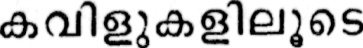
കവിളുകളിലൂടെ
